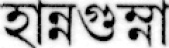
হান্নগুম্না
